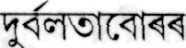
দুর্বলতাবোৰৰ
